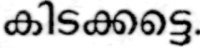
കിടക്കട്ടെ.
